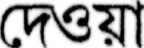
দেওয়া
